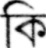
কি
